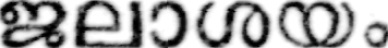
ജലാശയം
